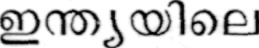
ഇന്ത്യയിലെ
